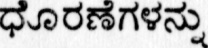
ಧೊರಣೆಗಳನ್ನು
